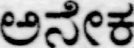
ಅನೇಕ
